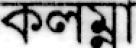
কলম্না
